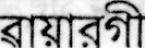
ৱায়ারগী
